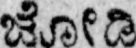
ಜೋಡಿ
